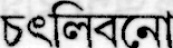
চৎলিবনো
